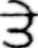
ਤੇ
